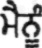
ਮੈਨੂੰ
